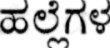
ಹಲ್ಲೆಗಳ
